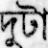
দুটা
